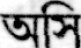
অসি
